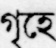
গৃহে
